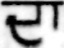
ਦਾ
